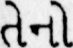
તેનો
